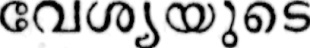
വേശ്യയുടെ
